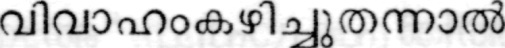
വിവാഹംകഴിച്ചുതന്നാല്‍
